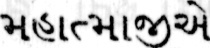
મહાત્માજીએ
